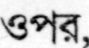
ওপর,
